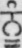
ਨੂੰ
